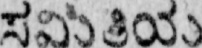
ಸಮಿತಿಯ
